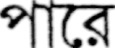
পারে
